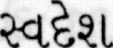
સ્વદેશ
